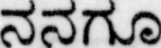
ನನಗೂ
